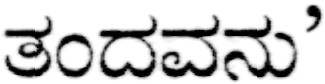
ತಂದವನು'
